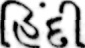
હિંદી
